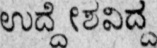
ಉದ್ದೇಶವಿದ್ದ
